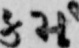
કર્મ
